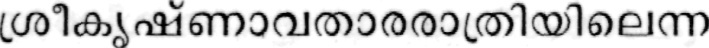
ശ്രീകൃഷ്ണാവതാരരാത്രിയിലെന്ന
